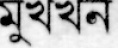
মুখখন
